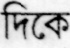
দিকে
